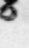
કે
